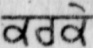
ਕਰਕੇ
